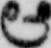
ಆ
